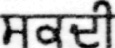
ਸਕਦੀ
